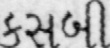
કસબી
